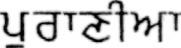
ਪੁਰਾਣੀਆ
